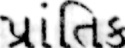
પ્રાંતિક
